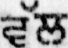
ਵੱਲ
